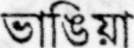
ভাঙিয়া
